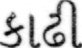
કાઢી
